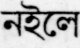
নইলে
